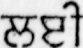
ਲਈ
